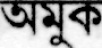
অমুক
